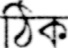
ঠিক
